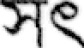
সৎ
